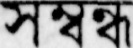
সম্বন্ধ
